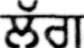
ਲੱਗ
